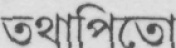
তথাপিতো
